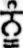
ਨੂੰ
